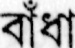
বাঁধা
